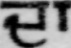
ਦਾ
